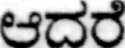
ಆದರೆ
